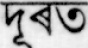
দূৰত
